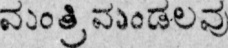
ಮಂತ್ರಿಮಂಡಲವು
